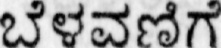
ಬೆಳವಣಿಗೆ
